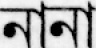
নানা
